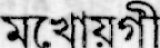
মখোয়গী
